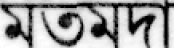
মতমদা
